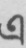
এ
